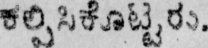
ಕಲ್ಪಿಸಿಕೊಟ್ಟರು.
